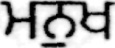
ਮਨੁਖ
